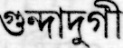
গুন্দাদুগী
